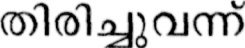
തിരിച്ചുവന്ന്
